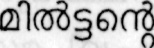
മില്‍ട്ടന്റെ
